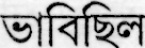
ভাবিছিল
